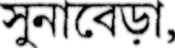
সুনাবেড়া,
